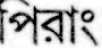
পিরাং
